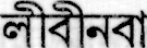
লীবীনবা
